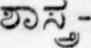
ಶಾಸ್ತ್ರ-
